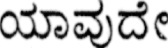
ಯಾವುದೇ
